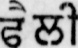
ਫੈਲੀ
